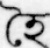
হৈ
